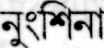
নুংশিনা
